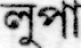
লুপা
